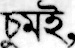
চুমই,
